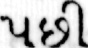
પછી
